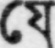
যে
